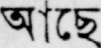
আছে
